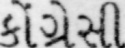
કોંગ્રેસી
